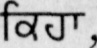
ਕਿਹਾ,
